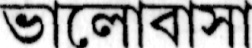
ভালোবাসা
